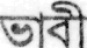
ভাবী
